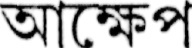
আক্ষেপ
